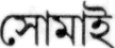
সোমাই
